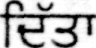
ਦਿੱਤਾ
